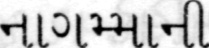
નાગમ્માની
